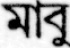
মাবু
